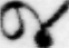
જ
